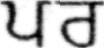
ਪਰ
